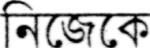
নিজেকে
